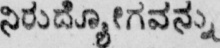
ನಿರುದ್ಯೋಗವನ್ನು
